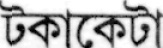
টকাকেটা
